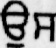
ਉਸ
